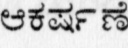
ಆಕರ್ಷಣೆ
